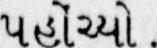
પહોંચ્યો.
